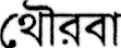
থৌরবা
